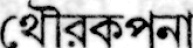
থৌরকপনা
